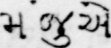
મંજુએ
